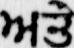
ਅਤੇ
